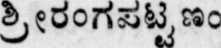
ಶ್ರೀರಂಗಪಟ್ಟಣಂ
